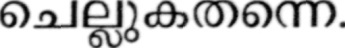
ചെല്ലുകതന്നെ.
